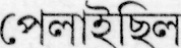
পেলাইছিল
